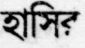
হাসির
